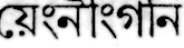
য়েংনীংগনি
